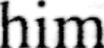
him
